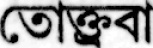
তোক্ত্রবা
